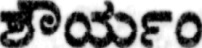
ಶೌರ್ಯ
